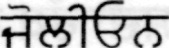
ਜੋਲੀਓਨ
